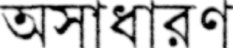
অসাধারণ
